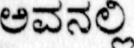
ಅವನಲ್ಲಿ
